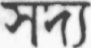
সদ্য
